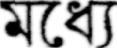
মধ্যে
